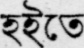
হইতে
